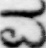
ವ
